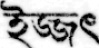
ইজ্জৎ
